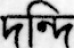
দন্দি
